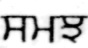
ਸਮਝ
